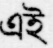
এই
